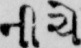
નીચે
